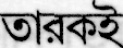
তারকই
